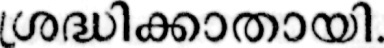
ശ്രദ്ധിക്കാതായി.
